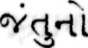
જંતુનો
